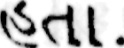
હતા.
